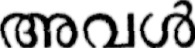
അവള്‍
